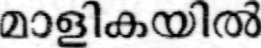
മാളികയില്‍
